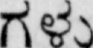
ಗಳು
